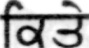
ਕਿਤੇ
